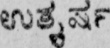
ಉತ್ಕರ್ಷ
